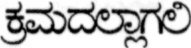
ಕ್ರಮದಲ್ಲಾಗಲಿ
